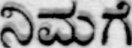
ನಿಮಗೆ
